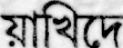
য়াখিদে
